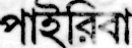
পাইরিবা
